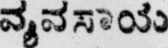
ವ್ಯವಸಾಯ
